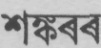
শঙ্কৰৰ
